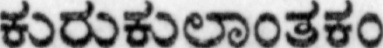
ಕುರುಕುಲಾಂತಕಂ
